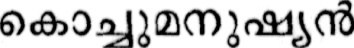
കൊച്ചുമനുഷ്യന്‍
